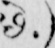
છે.)
